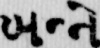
બન્ને
